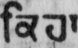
ਕਿਹਾ
